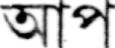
আপ
